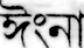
ঈংনা
